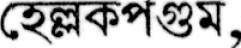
হেল্লকপগুম,
